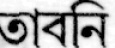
তাবনি
